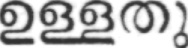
ഉള്ളതു
